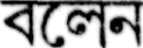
বলেন
